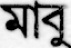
মাবু
